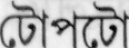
টোপটো
